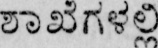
ಶಾಖೆಗಳಲ್ಲಿ
